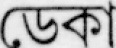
ডেকা
